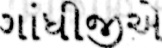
ગાંધીજીએ
